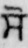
ਸੋ
